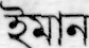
ইমান
